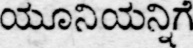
ಯೂನಿಯನ್ನಿಗೆ
